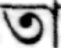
তা
